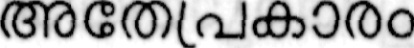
അതേപ്രകാരം
